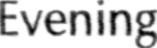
Evening
